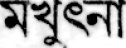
মখুৎনা
